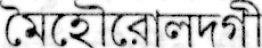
মৈহৌরোলদগী
